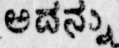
ಅದನ್ನು
